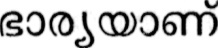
ഭാര്യയാണ്
